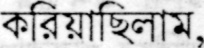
করিয়াছিলাম,
